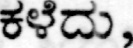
ಕಳೆದು,
